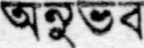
অনুভব
